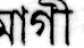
মাগী
